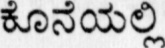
ಕೊನೆಯಲ್ಲಿ
